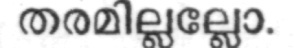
തരമില്ലല്ലോ.
